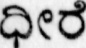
ಧೀರೆ
